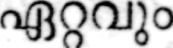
ഏറ്റവും
